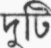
দুটি
